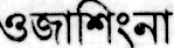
ওজাশিংনা
